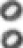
ঃ
